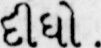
દીધો.
